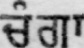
ਚੰਗਾ
